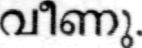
വീണു.
